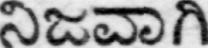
ನಿಜವಾಗಿ
